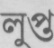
লুপ্ত
